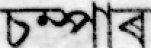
চম্পাৰ
